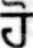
ਹੋ
